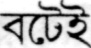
বটেই
